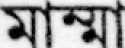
মাম্মা
